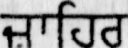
ਜ਼ਾਹਿਰ
